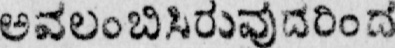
ಅವಲಂಬಿಸಿರುವುದರಿಂದ
